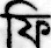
ফি
